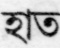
হাত
